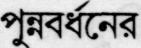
পুন্নবর্ধনের
